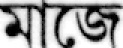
মাজে
